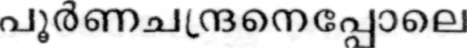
പൂര്‍ണചന്ദ്രനെപ്പോലെ
